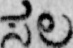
ಸಲ
